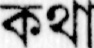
কথা
